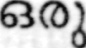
ഒരു
